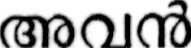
അവന്‍
